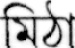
মিঠা
